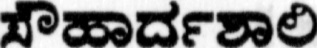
ಸೌಹಾರ್ದಶಾಲಿ
